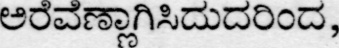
ಅರೆವೆಣ್ಣಾಗಿಸಿದುದರಿಂದ,
